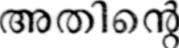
അതിന്റെ
